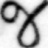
જ
